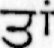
ਤਾਂ
